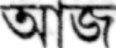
আজ
